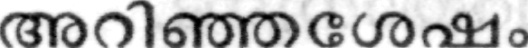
അറിഞ്ഞശേഷം
